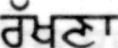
ਰੱਖਣਾ
